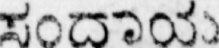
ಸಂದಾಯ
